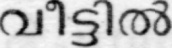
വീട്ടില്‍
